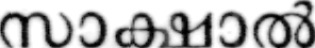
സാക്ഷാല്‍
